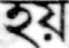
হয়
